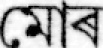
মোৰ
